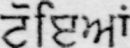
ਟੋਇਆਂ
